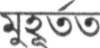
মুহূর্তত
